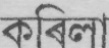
কৰিলা
